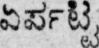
ಏರ್ಪಟ್ಟಿ
